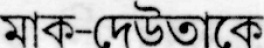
মাক-দেউতাকে
